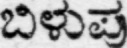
ಬಿಳುಪು
